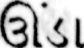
ઊંડા
